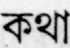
কথা
